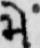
મેં
